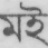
মই
